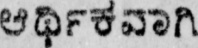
ಆರ್ಥಿಕವಾಗಿ
